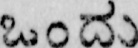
ಒಂದು
